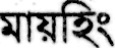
মায়হিং
